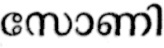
സോണി
